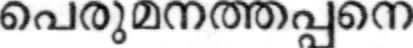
പെരുമനത്തപ്പനെ
